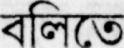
বলিতে
